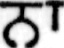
ਨਾ
